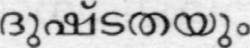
ദുഷ്ടതയും
